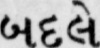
બદલે
